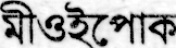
মীওইপোক
